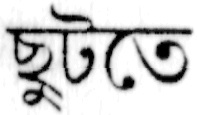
ছুটতে
